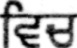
ਵਿਚ
